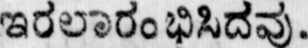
ಇರಲಾರಂಭಿಸಿದವು.
